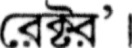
রেক্টর'।
